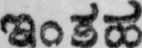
ಇಂತಹ
